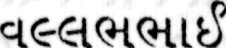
વલ્લભભાઈ
